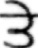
ਤੇ
